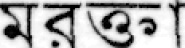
মরক্তা
